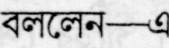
বললেন–এ
